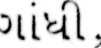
ગાંધી,
